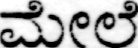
ಮೇಲೆ
